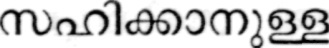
സഹിക്കാനുള്ള
